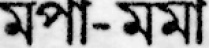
মপা-মমা
